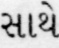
સાથે
